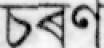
চৰণ
